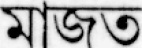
মাজত
